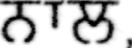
ਨਾਲ,
